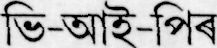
ভি-আই-পিৰ
